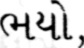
ભયો,
